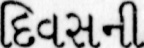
દિવસની
